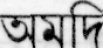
অমদি
